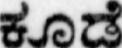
ಕೂಡೆ
